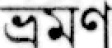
ভ্রমণ
